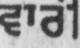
ਵਾਰੀ
